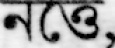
নত্তে,
